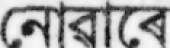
নোৱাৰে
